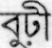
বুঢ়ী
